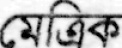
মেত্রিক
